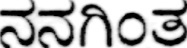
ನನಗಿಂತ
